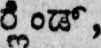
ರ್‍ಲೆಂಡ್,
